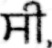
ਸੀ,
